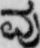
ವು
